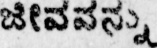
ಜೀವವನ್ನು
